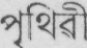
পৃথিৱী
